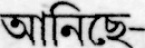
আনিছে-
